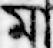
মা
